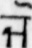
ਜੋ
